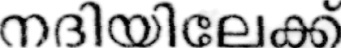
നദിയിലേക്ക്
